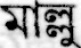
মাল্লু
